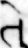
તો
